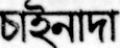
চাইনাদা
